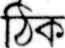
ঠিক
